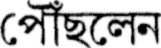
পৌঁছলেন
